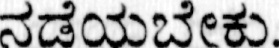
ನಡೆಯಬೇಕು.
